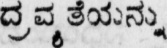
ದ್ರವ್ಯತೆಯನ್ನು
